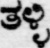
ತಳ್ಳಿ
